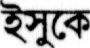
ইসুকে
